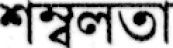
শম্বলতা
